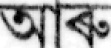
আৰু
